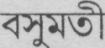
বসুমতী
